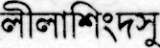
লীলাশিংদসু
